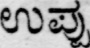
ಉಪ್ಪು
